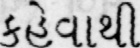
કહેવાથી
